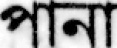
পানা
